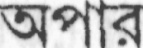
অপার
